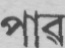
পাৱ
